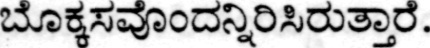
ಬೊಕ್ಕಸವೊಂದನ್ನಿರಿಸಿರುತ್ತಾರೆ.
